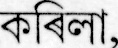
কৰিলা,
